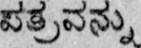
ಪತ್ರವನ್ನು
